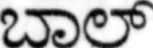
ಬಾಲ್
